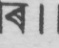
ৰ।
